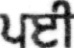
ਪਈ
